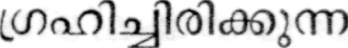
ഗ്രഹിച്ചിരിക്കുന്ന
